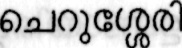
ചെറുശ്ശേരി
